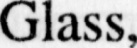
Glass,
